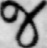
જ
